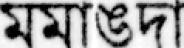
মমাঙদা
